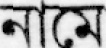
নামে
